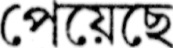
পেয়েছে
